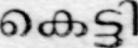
കെട്ടി
